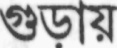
গুড়ায়
